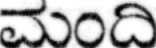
ಮಂದಿ
